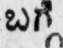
ಬಗ್ಗೆ
